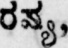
ರಷ್ಯ,
